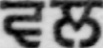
ਵਲ
